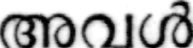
അവള്‍
